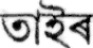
তাইৰ
